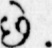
છે.
